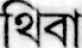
থিবা
